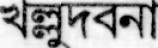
খল্লুদবনা
